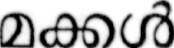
മക്കള്‍
